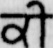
ਕੀ
